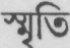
স্মৃতি
